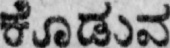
ಕೊಡುವ
